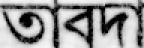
তাবদা
